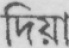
দিয়া
